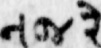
નજરે
